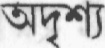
অদৃশ্য
